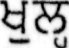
ਖੁਲ੍ਹ
